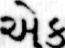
એક
